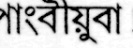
পাংবীয়ুবা
